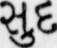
સુદ
